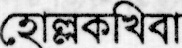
হোল্লকখিবা
